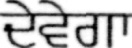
ਦੇਵੇਗਾ
